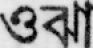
ওঝা
